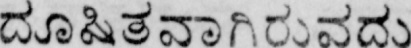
ದೂಷಿತವಾಗಿರುವದು
